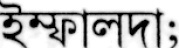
ইম্ফালদা;
